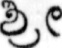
ಶ್ರೀ
